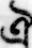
ঐ
